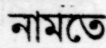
নামতে
